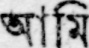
আমি
